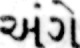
અંગે
